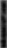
I
